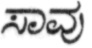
ಸಾವು
